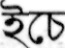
ইচে
